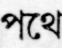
পথে
